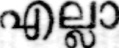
എല്ലാ
